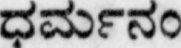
ಧರ್ಮನಂ
